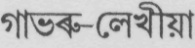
গাভৰু-লেখীয়া
